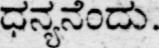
ಧನ್ಯನೆಂದು.
